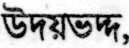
উদয়ভদ্দ,
